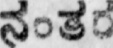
ನಂತರ
